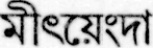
মীৎয়েংদা
